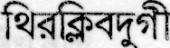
থিরক্লিবদুগী
